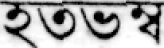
হতভম্ব
